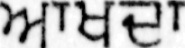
ਆਖਦਾ
